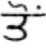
ਤੋਂ
